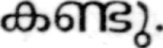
കണ്ടു.
